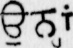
ਉਨ੍ਹਾਂ
